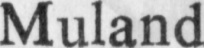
Muland
